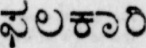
ಫಲಕಾರಿ
